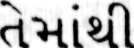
તેમાંથી
